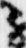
કે
